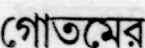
গোতমের
